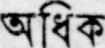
অধিক
